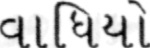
વાધિયો
